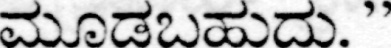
ಮೂಡಬಹುದು."
